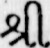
શ્રી
